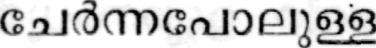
ചേര്‍ന്നപോലുള്ള
